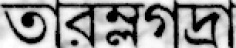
তারম্লগদ্রা
